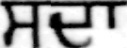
ਸਦਾ
